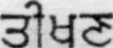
ਤੀਖਣ
